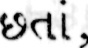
છતાં,
